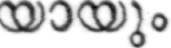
യായും
